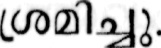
ശ്രമിച്ചു.
